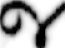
જ
